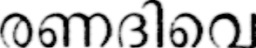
രണദിവെ
